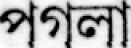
পগলা
